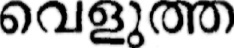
വെളുത്ത
